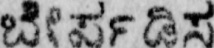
ಬೇರ್ಪಡಿಸ
